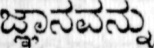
ಜ್ಞಾನವನ್ನು
